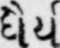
ધૈર્ય
